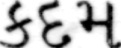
કદમ
